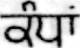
ਕੰਧਾਂ
